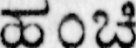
ಹಂಚಿ
